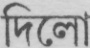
দিলো
